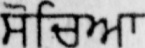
ਸੋਚਿਆ
